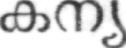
കന്യ
